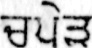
ਚਪੇੜ
